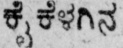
ಕೈಕೆಳಗಿನ
